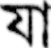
যা
